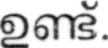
ഉണ്ട്.
